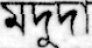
মদুদা
